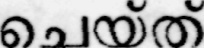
ചെയ്ത്
